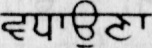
ਵਧਾਉਣਾ
